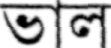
ভাল
